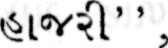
હાજરી",
